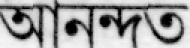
আনন্দত
